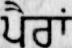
ਪੈਰਾਂ
